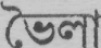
ভৈলা
